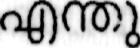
എന്തു
